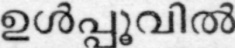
ഉള്‍പ്പൂവില്‍
